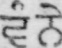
ਵੰਨੇ
